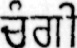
ਚੰਗੀ
